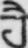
ਹੈ
